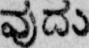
ವುದು
